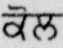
ਕੋਲ
